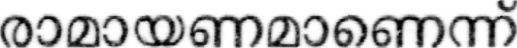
രാമായണമാണെന്ന്
